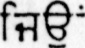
ਜਿਉਂ
